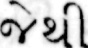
જેથી
